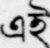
এই
